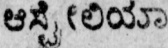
ಆಸ್ಟ್ರೇಲಿಯಾ
